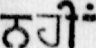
ਨਹੀਂ
